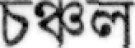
চঞ্চল
